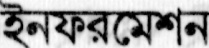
ইনফরমেশন
